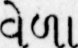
વેળા
